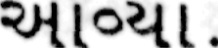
આવ્યા.
